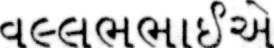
વલ્લભભાઈએ
